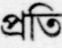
প্রতি
